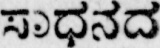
ಸಾಧನದ
